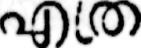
എത്ര
